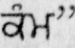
ਕੰਮ''
